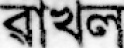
ৱাখল
